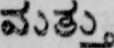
ಮತ್ತು
